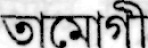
তামোগী
